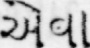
એવા
